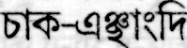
চাক-এঞ্ছাংদি
